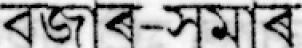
বজাৰ-সমাৰ
